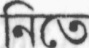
নিতে
